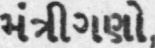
મંત્રીગણો,
